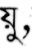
য়ু,
